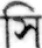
সি
